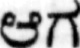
ಆಗ
